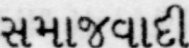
સમાજવાદી
